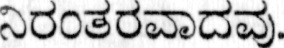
ನಿರಂತರವಾದವು.
